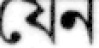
যেন
